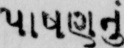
પાષણનું
